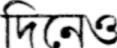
দিনেও
